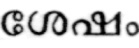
ശേഷം
